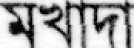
মখাদা
